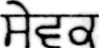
ਸੇਵਕ
